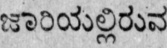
ಜಾರಿಯಲ್ಲಿರುವ
